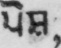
ਪੋਸ਼,
